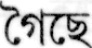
গৈছে
